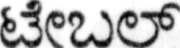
ಟೇಬಲ್
